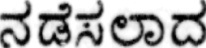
ನಡೆಸಲಾದ
